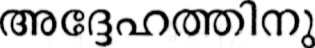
അദ്ദേഹത്തിനു
